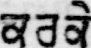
ਕਰਕੇ
